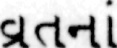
વ્રતનાં
